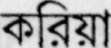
করিয়া
